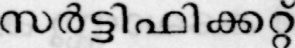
സര്‍ട്ടിഫിക്കറ്റ്
